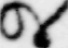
જ
